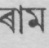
ৰাম
